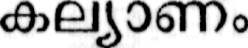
കല്യാണം
